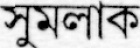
সুমলাক
